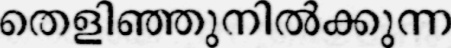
തെളിഞ്ഞുനില്‍ക്കുന്ന
